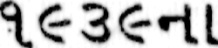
૧૯૩૯ના
